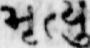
મૃત્યુ
